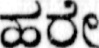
ಹರೇ
